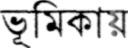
ভূমিকায়
